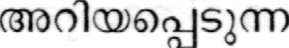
അറിയപ്പെടുന്ന
